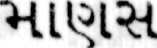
માણસ
